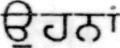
ਉਹਨਾਂ
